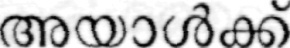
അയാള്‍ക്ക്
